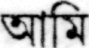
আমি
